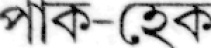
পাক-হেক
